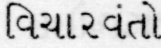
વિચારવંતો
